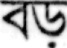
বড়
